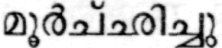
മൂര്‍ച്ഛിച്ചു
